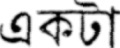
একটা
